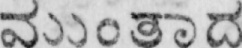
ಮುಂತಾದ
